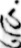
હું
